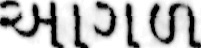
આગળ
